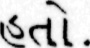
હતો.
